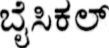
ಬೈಸಿಕಲ್
